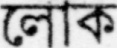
লোক
